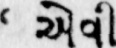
'એવી
